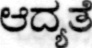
ಆದ್ಯತೆ
